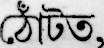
ঠোঁটত,
